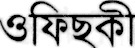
ওফিছকী
